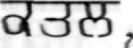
ਕਤਲ,
